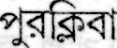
পুরক্লিবা
